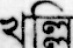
খল্লি
